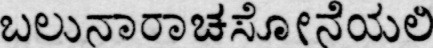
ಬಲುನಾರಾಚಸೋನೆಯಲಿ
